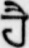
ਹੈ
